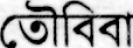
তৌবিবা
